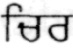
ਚਿਰ
